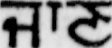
ਜਾਣ
